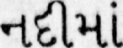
નદીમાં
